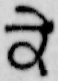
ਕੇ
